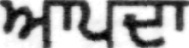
ਆਪਦਾ
